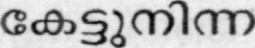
കേട്ടുനിന്ന
